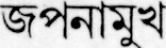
জপনামুখ
